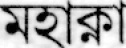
মহাক্না
